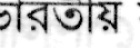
ভারতীয়
